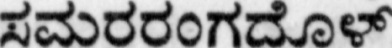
ಸಮರರಂಗದೊಳ್
